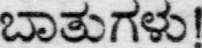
ಬಾತುಗಳು!
